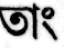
তাং
